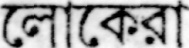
লোকেরা
